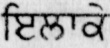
ਇਲਾਕੇ
